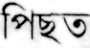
পিছত
